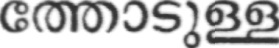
ത്തോടുള്ള
